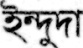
ইন্দুদা
